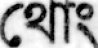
থোং
